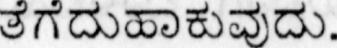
ತೆಗೆದುಹಾಕುವುದು.
